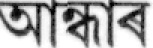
আন্ধাৰ
